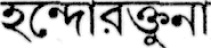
হন্দোরক্তুনা
